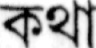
কথা
